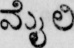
ಮೈಲಿ
